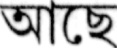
আছে
